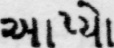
આપ્યો
